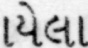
।યેલા
